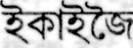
ইকাইজৈ
